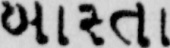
બાસ્તા
